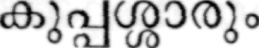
കുപ്പശ്ശാരും
